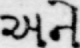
અને
